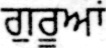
ਗੁਰੂਆਂ
